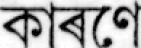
কাৰণে
